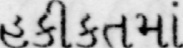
હકીકતમાં
